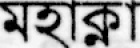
মহাক্না
